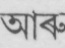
আৰু
